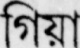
গিয়া
